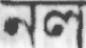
নল
